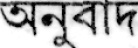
অনুবাদ
